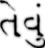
તેવું
